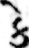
કે
